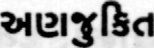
અણજુક્તિ
